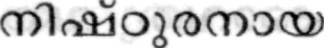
നിഷ്ഠുരനായ
